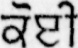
ਕੋਈ
